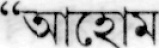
"আহোম
